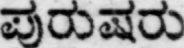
ಪುರುಷರು
